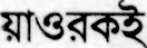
য়াওরকই
